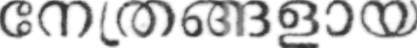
നേത്രങ്ങളായ
